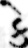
કે
